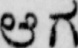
ಆಗ
